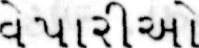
વેપારીઓ
